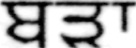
ਬੜਾ
